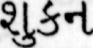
શુકન
